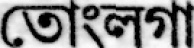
তোংলগা
